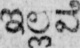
ಇಲ್ಲವೆ
